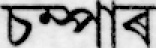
চম্পাৰ
